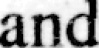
and
